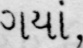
ગયાં,
